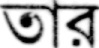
তার
